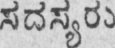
ಸದಸ್ಯರು
